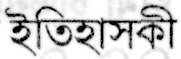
ইতিহাসকী
